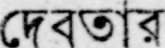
দেবতার
